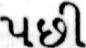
પછી
